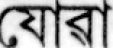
যোৱা
